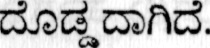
ದೊಡ್ಡದಾಗಿದೆ.
